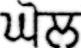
ਘੋਲ
